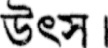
উৎস।
